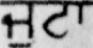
ਜੁਟਾ
